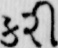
કરી
